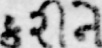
કરીને
